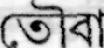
তৌবা
